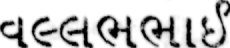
વલ્લભભાઈ
